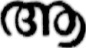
ആ
